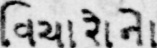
વિચારોનો
